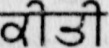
ਕੀਤੀ
